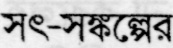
সত্-সঙ্কল্পের
